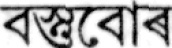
বস্তুবোৰ
